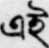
এই
